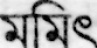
মমিৎ
